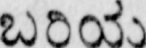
ಬರಿಯ
